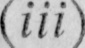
(iii)
